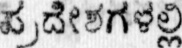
ಪ್ರದೇಶಗಳಲ್ಲಿ
